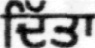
ਦਿੱਤਾ
